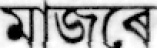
মাজৰে
